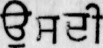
ਉਸਦੀ
